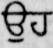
ਉਹ
